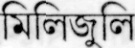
মিলিজুলি
